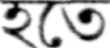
হতে
